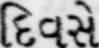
દિવસે
